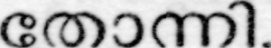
തോന്നി.
